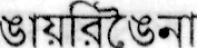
ঙায়রিঙৈনা
